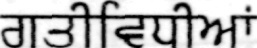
ਗਤੀਵਿਧੀਆਂ
